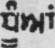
ਧੂੰਆਂ
